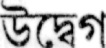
উদ্বেগ
